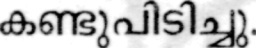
കണ്ടുപിടിച്ചു.
